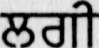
ਲਗੀ
